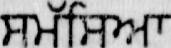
ਸਮੱਸਿਆ
